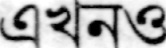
এখনও
